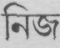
নিজ
